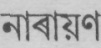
নাৰায়ণ
